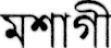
মশাগী
